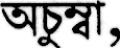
অচুম্বা,
